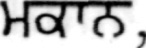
ਮਕਾਨ,
